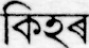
কিহৰ
